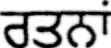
ਰਤਨਾਂ
